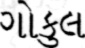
ગોકુલ
